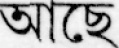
আছে
